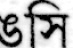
ঙসি
